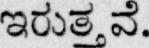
ಇರುತ್ತವೆ.
